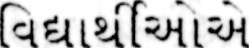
વિધાર્થીઓએ
